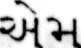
એમ
